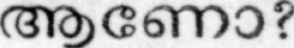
ആണോ?
